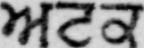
ਅਟਕ
